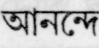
আনন্দে
